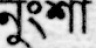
নুংশা
